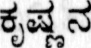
ಕೃಷ್ಣನ
